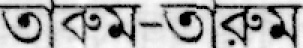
তারুম-তারুম
